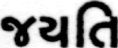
જયતિ
